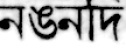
নঙনদি
